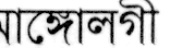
মাঙ্গোলগী
